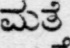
ಮತ್ತೆ
